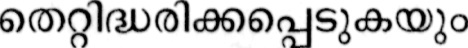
തെറ്റിദ്ധരിക്കപ്പെടുകയും
